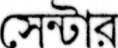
সেন্টার
